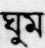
ঘুম
